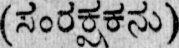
(ಸಂರಕ್ಷಕನು)
